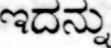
ಇದನ್ನು
